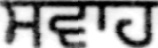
ਸਵਾਹ
